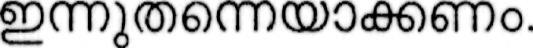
ഇന്നുതന്നെയാക്കണം.
